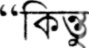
“কিন্তু
